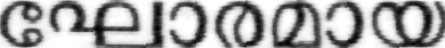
ഘോരമായ
